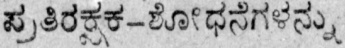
ಪ್ರತಿರಕ್ಷಕ-ಶೋಧನೆಗಳನ್ನು
